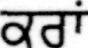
ਕਰਾਂ
